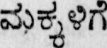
ಮಕ್ಕಳಿಗೆ
